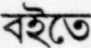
বইতে
